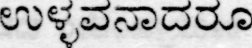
ಉಳ್ಳವನಾದರೂ
